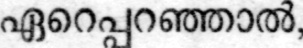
ഏറെപ്പറഞ്ഞാല്‍,
